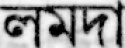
লমদা
